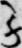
કે
